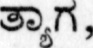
ತ್ಯಾಗ,
